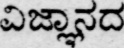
ವಿಜ್ಞಾನದ
